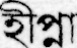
হীপ্না
